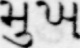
મુખ
